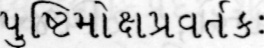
પુષ્ટિમોક્ષપ્રવર્તકઃ
